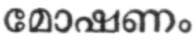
മോഷണം
